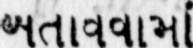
બતાવવામાં
